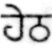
ਹੇਠ
